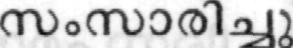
സംസാരിച്ചു
